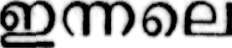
ഇന്നലെ
